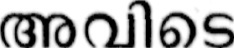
അവിടെ
